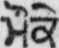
ਮੌਕੇ
